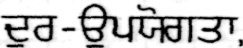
ਦੁਰ-ਉਪਯੋਗਤਾ
